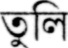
তুলি
